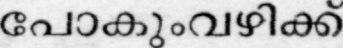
പോകുംവഴിക്ക്
